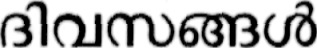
ദിവസങ്ങള്‍
